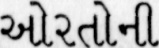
ઓરતોની
